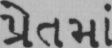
પ્રેતમાં
